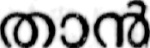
താന്‍
